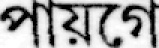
পায়গে
